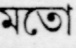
মতো
